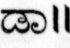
ಡಾ||
